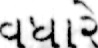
વધારે
